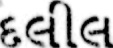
દલીલ
